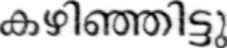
കഴിഞ്ഞിട്ടു
